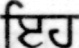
ਇਹ
